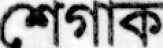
শেগাক
